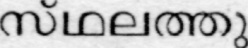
സ്ഥലത്തു
